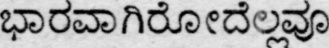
ಭಾರವಾಗಿರೋದೆಲ್ಲವೂ
